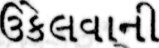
ઉકેલવાની
